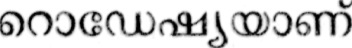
റൊഡേഷ്യയാണ്
